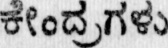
ಕೇಂದ್ರಗಳು
